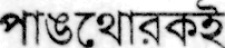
পাঙথোরকই
